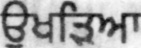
ਉਖੜਿਆ
